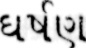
ઘર્ષણ
